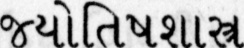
જ્યોતિષશાસ્ત્ર
